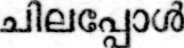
ചിലപ്പോള്‍
